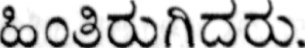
ಹಿಂತಿರುಗಿದರು.
